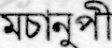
মচানুপী
